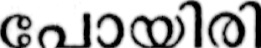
പോയിരി
